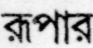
রূপার
